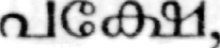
പക്ഷേ,
